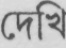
দেখি
